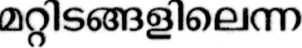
മറ്റിടങ്ങളിലെന്ന
